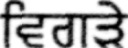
ਵਿਗੜੇ
